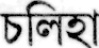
চলিহা
